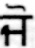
ਜੋ
